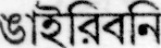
ঙাইরিবনি
